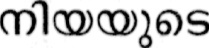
നിയയുടെ
